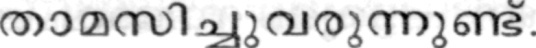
താമസിച്ചുവരുന്നുണ്ട്.
